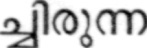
ച്ചിരുന്ന
